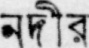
নদীর
